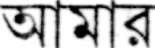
আমার
